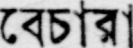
বেচারা
